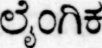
ಲೈಂಗಿಕ
